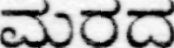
ಮರದ
